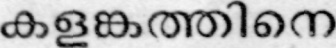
കളങ്കത്തിനെ
